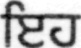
ਇਹ
